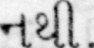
નથી.
